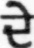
ਦੇ
